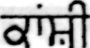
ਕਾਂਸ਼ੀ
